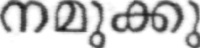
നമുക്കു
